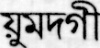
য়ুমদগী
